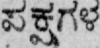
ಪಕ್ಷಗಳ
